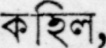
কহিল,
